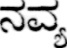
ನವ್ಯ
